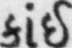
કાંઈ
